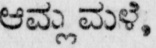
ಆಮ್ಲಮಳೆ,
